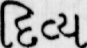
દિવ્ય
